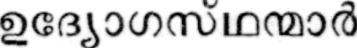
ഉദ്യോഗസ്ഥന്മാര്‍
